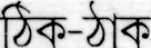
ঠিক-ঠাক
